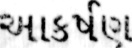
આકર્ષણ
